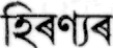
হিৰণ্যৰ
